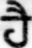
ਹੈ
